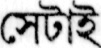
সেটাই
